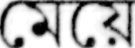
মেয়ে
